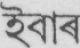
ইবাৰ
